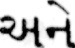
અને
